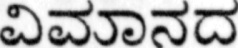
ವಿಮಾನದ
